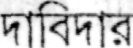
দাবিদার
